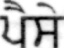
ਪੈਸੇ
